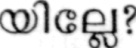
യില്ലേ?
